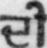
ਦੀ
